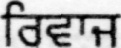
ਰਿਵਾਜ
